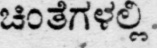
ಚಿಂತೆಗಳಲ್ಲಿ
